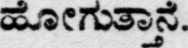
ಹೋಗುತ್ತಾನೆ.
